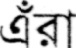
এঁরা
